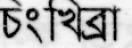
চিংখিব্রা
